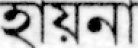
হায়না
